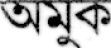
অমুক
